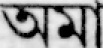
অমা
